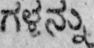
ಗಳನ್ನು
